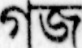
গজ
